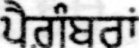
ਪੈਗ਼ੰਬਰਾਂ
